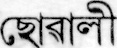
ছোৱালী
